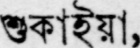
শুকাইয়া,
